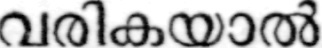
വരികയാല്‍
